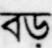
বড়
